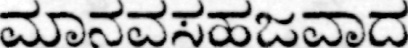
ಮಾನವಸಹಜವಾದ
